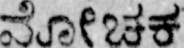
ಮೋಚಕ
